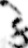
કે
